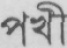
পখী
